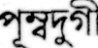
পূম্বদুগী
